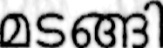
മടങ്ങി
